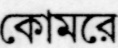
কোমরে
